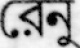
রেনু
